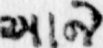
આજે
